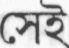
সেই
